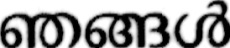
ഞങ്ങള്‍
